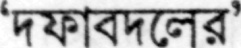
‘দফাবদলের’
